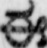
ಈ
